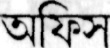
অফিস
